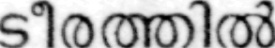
ടീരത്തില്‍
